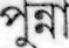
পুন্না
